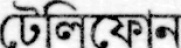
টেলিফোন
